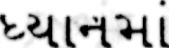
ધ્યાનમાં
